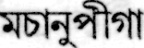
মচানুপীগা
